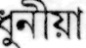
ধুনীয়া
